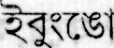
ইবুংঙো
